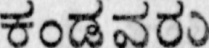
ಕಂಡವರು
